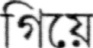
গিয়ে
